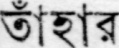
তাঁহার
